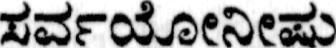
ಸರ್ವಯೋನೀಷು
